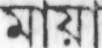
মায়া
